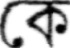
কে
